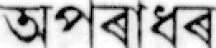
অপৰাধৰ
